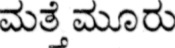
ಮತ್ತೆಮೂರು
